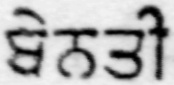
ਬੇਨਤੀ
